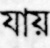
যায়
